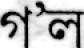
গ'ল
